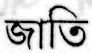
জাতি
